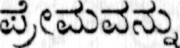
ಪ್ರೇಮವನ್ನು
